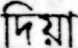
দিয়া
